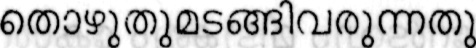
തൊഴുതുമടങ്ങിവരുന്നതു
